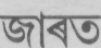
জাৰত
